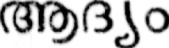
ആദ്യം
